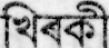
খিৰকী
